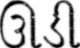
ઊડી
